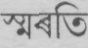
স্মৰতি
